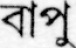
বাপু
